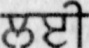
ਲਈ
